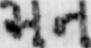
મન
